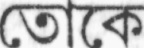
তোকে
